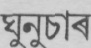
ঘুনুচাৰ
